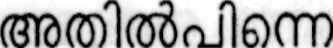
അതില്‍പിന്നെ
